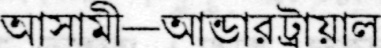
আসামী-আন্ডারট্রায়াল
